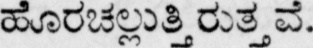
ಹೊರಚಲ್ಲುತ್ತಿರುತ್ತವೆ.
